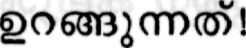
ഉറങ്ങുന്നത്!
